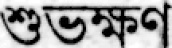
শুভক্ষণ
